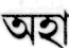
অহা
